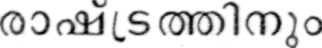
രാഷ്ട്രത്തിനും
